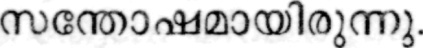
സന്തോഷമായിരുന്നൂ.
